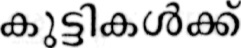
കുട്ടികള്‍ക്ക്
